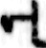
ન
